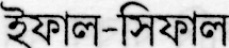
ইফাল-সিফাল
